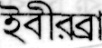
ইবীরব্রা
